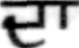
ਦਾ
